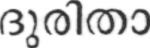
ദുരിതാ
